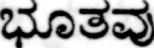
ಭೂತವು
